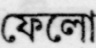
ফেলো
